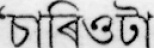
'চাৰিওটা
